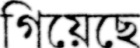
গিয়েছে
